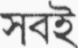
সবই
